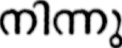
നിന്നു
